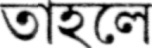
তাহলে
